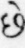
છે
